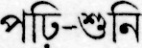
পঢ়ি-শুনি
